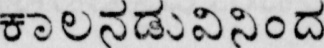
ಕಾಲನಡುವಿನಿಂದ
